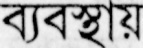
ব্যবস্থায়
